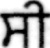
ਸੀ
